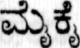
ಮೈಕೈ
